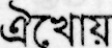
ঐখোয়
